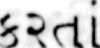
કરતાં
